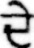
ਦੇ
